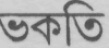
ভকতি
